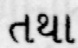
તથા
